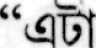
"এটা
